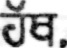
ਹੱਥ,
